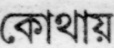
কোথায়
